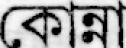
কোন্না
